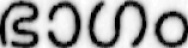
ഭാഗം
